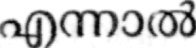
എന്നാല്‍
